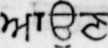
ਆਉਣ
